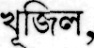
খূজিল,
